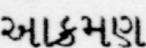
આક્રમણ
